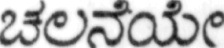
ಚಲನೆಯೇ
